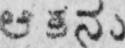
ಆತನು
